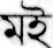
মই
